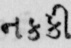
નક્કી
